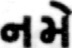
નમે
